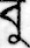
বু
